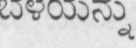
ಬೆಳೆಯನ್ನು
